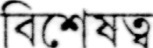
বিশেষত্ব
